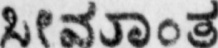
ಸೀಮಾಂತ
